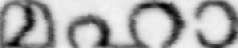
മഹാ
